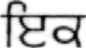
ਇਕ
